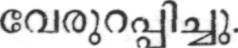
വേരുറപ്പിച്ചു.
